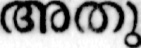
അതു
